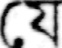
যে
